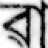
ৱা
